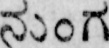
ನುಂಗ
